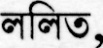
ললিত,
